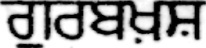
ਗੁਰਬਖ਼ਸ਼
